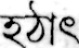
হঠাৎ
